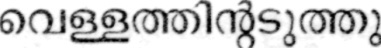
വെള്ളത്തിന്റടുത്തു
